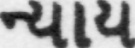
ન્યાય
